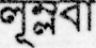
লূম্লবা
